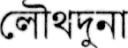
লৌথদুনা
